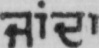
ਜਾਂਦਾ
